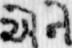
એને
